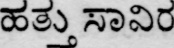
ಹತ್ತುಸಾವಿರ
